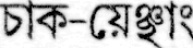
চাক-য়েঞ্ছাং
